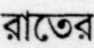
রাতের
